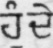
ਹੁੰਦੇ
